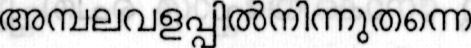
അമ്പലവളപ്പില്‍നിന്നുതന്നെ
